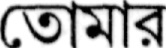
তোমার
